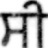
ਸੀ
